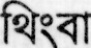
থিংবা
